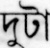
দুটা
